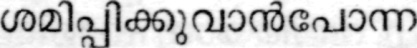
ശമിപ്പിക്കുവാന്‍പോന്ന
